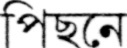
পিছনে
